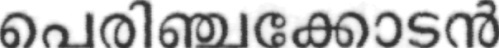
പെരിഞ്ചക്കോടന്‍
